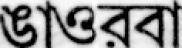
ঙাওরবা
